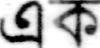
এক
